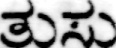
ತುಸು
